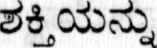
ಶಕ್ತಿಯನ್ನು
